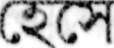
হেসে
